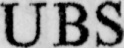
UBS
